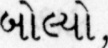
બોલ્યો,
